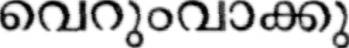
വെറുംവാക്കു
